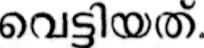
വെട്ടിയത്.
